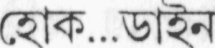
হোক...ডাইন
